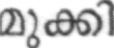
മുക്കി
